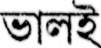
ভালই
